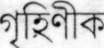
গৃহিণীক
